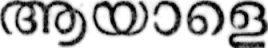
ആയാളെ
